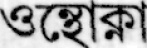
ওন্থোক্না
